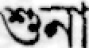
শুনা
